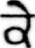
ਕੇ
